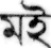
মই
